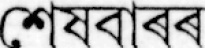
শেষবাৰৰ
